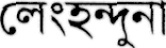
লেংহন্দুনা
